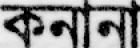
কনানা
